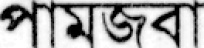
পামজবা
